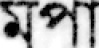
মপা
